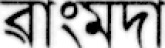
ৱাংমদা
